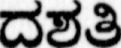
ದಶತಿ
